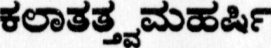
ಕಲಾತತ್ತ್ವಮಹರ್ಷಿ
